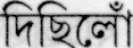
দিছিলোঁ
